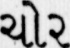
ચોર
